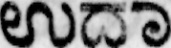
ಉದಾ
